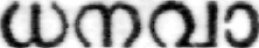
ധനവാ
